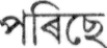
পৰিছে
